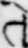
તે
